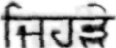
ਜਿਹੜੇ
